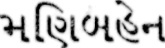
મણિબહેન
